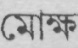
মোক্ষ
